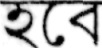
হবে
